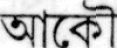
আকৌ
